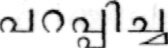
പറപ്പിച്ച
